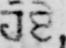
ਹੋਏ,
